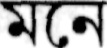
মনে
